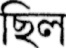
ছিল
